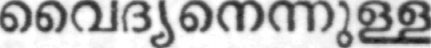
വൈദ്യനെന്നുള്ള
